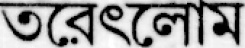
তরেৎলোম
